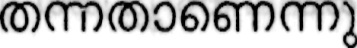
തന്നതാണെന്നു
